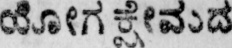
ಯೋಗಕ್ಷೇಮದ
